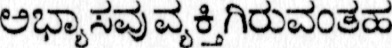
ಅಭ್ಯಾಸವುವ್ಯಕ್ತಿಗಿರುವಂತಹ
